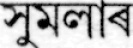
সুমলাৰ
